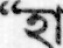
“হা
